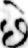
છે
